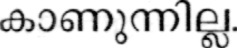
കാണുന്നില്ല.
